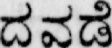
ದವಡೆ
